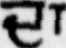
ਦਾ
